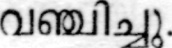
വഞ്ചിച്ചു.
